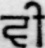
ਵੀ
